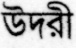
উদরী
